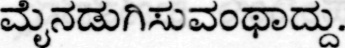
ಮೈನಡುಗಿಸುವಂಥಾದ್ದು.
